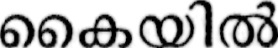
കൈയില്‍
